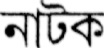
নাটক
